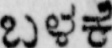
ಬಳಕೆ
